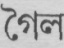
গৈল
